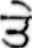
ਤੇ
